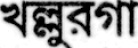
খুল্লুরগা
